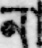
না
